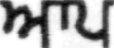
ਆਪ
